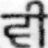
ਵੀ
